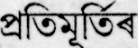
প্রতিমূর্তিৰ
